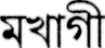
মখাগী
